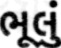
ભૂલું
